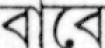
বাবে
